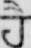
ਹੈ
